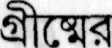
গ্রীষ্মের
